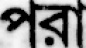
পরা
